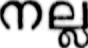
നല്ല
